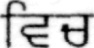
ਵਿਚ
